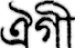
ঐগী
